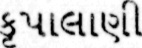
કૃપાલાણી
